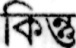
কিন্তু
